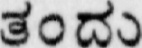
ತಂದು
